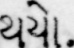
થયો.
